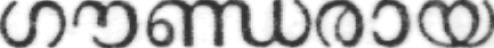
ഗൗണ്ഡരായ
